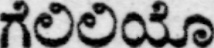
ಗೆಲಿಲಿಯೊ
